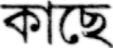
কাছে
